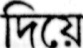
দিয়ে
